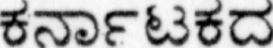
ಕರ್ನಾಟಕದ
